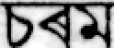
চৰম
